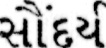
સૌંદર્ય
